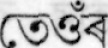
তেওঁৰ
